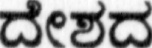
ದೇಶದ
